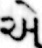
એ
